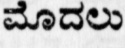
ಮೊದಲು
